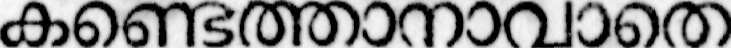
കണ്ടെത്താനാവാതെ
